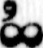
ಹಿ
